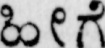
ಹೀಗೆ
